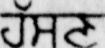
ਹੱਸਣ
